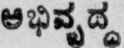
ಅಭಿವೃದ್ಧ
